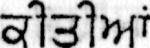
ਕੀਤੀਆਂ
